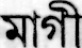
মাগী
